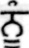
ਨੂੰ
